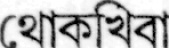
থোকখিবা
